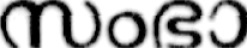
സംഭാ
